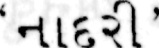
'નાદરી'
